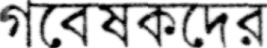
গবেষকদের
